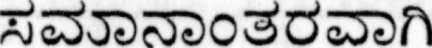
ಸಮಾನಾಂತರವಾಗಿ
